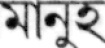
মানুহ
